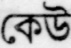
কেউ
